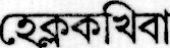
হেক্লকখিবা
